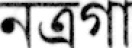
নত্রগা
